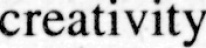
creativity
